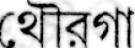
থৌরগা
